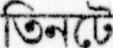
তিনটে
